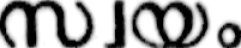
സ്വയം
